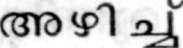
അഴിച്ച്
